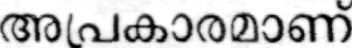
അപ്രകാരമാണ്
